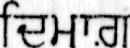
ਦਿਮਾਗ਼
